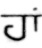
ਹਾਂ
